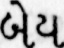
બેય
